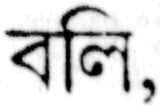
বলি,
